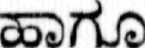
ಹಾಗೂ
